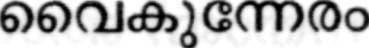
വൈകുന്നേരം
